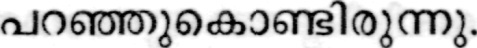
പറഞ്ഞുകൊണ്ടിരുന്നു.
